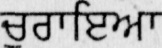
ਚੁਰਾਇਆ
